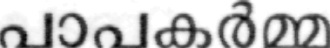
പാപകര്‍മ്മ
